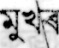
মুখৰ
